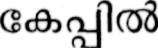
കേപ്പില്‍
